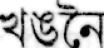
খঙনৈ
